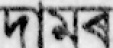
দামৰ
